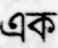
এক
